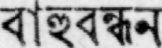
বাহুবন্ধন
